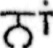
ਨਾਂ
